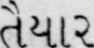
તૈયાર
